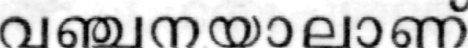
വഞ്ചനയാലാണ്
